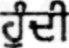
ਹੁੰਦੀ
